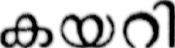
കയറി
